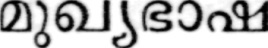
മുഖ്യഭാഷ
